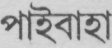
পাইবাহা
